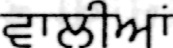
ਵਾਲੀਆਂ
